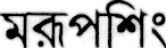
মরূপশিং
